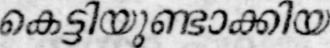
കെട്ടിയുണ്ടാക്കിയ
